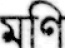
মণি
